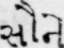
સૌને
